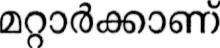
മറ്റാര്‍ക്കാണ്
